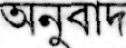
অনুবাদ
